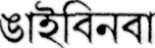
ঙাইবিনবা
